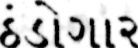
ઠંડોગાર
